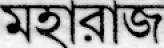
মহারাজ
